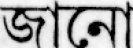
জানো
